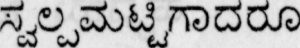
ಸ್ವಲ್ಪಮಟ್ಟಿಗಾದರೂ
